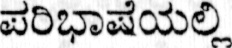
ಪರಿಭಾಷೆಯಲ್ಲಿ
